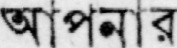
আপনার
